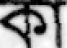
কা
